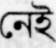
নেই
